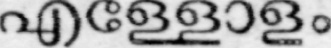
എള്ളോളം
